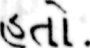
હતો.
